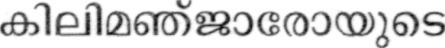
കിലിമഞ്ജാരോയുടെ
